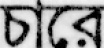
চারে
